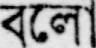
বলো
